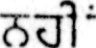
ਨਹੀਂ
